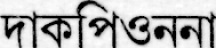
দাকপিওননা
